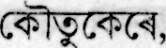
কৌতুকেৰে,
